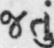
જતું
